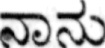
ನಾನು
